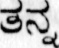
ತನ್ನ
